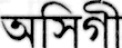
অসিগী
